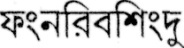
ফংনরিবশিংদু
